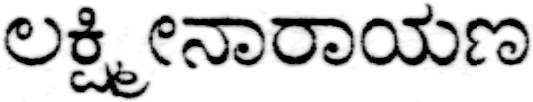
ಲಕ್ಷ್ಮೀನಾರಾಯಣ
